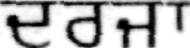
ਦਰਜਾ
